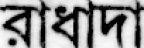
রাধাদা
